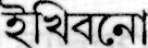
ইখিবনো
